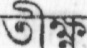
তীক্ষ্ণ
